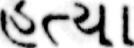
હત્યા
